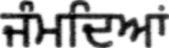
ਜੰਮਦਿਆਂ
